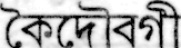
কৈদৌবগী
